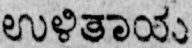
ಉಳಿತಾಯ
